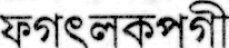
ফগৎলকপগী
